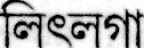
লিৎলগা
